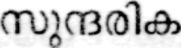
സുന്ദരിക
